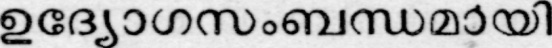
ഉദ്യോഗസംബന്ധമായി
